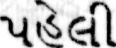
પહેલી
